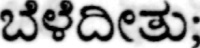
ಬೆಳೆದೀತು;
